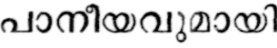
പാനീയവുമായി
